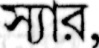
স্যার,
